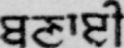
ਬਣਾਈ
